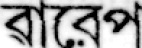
ৱারেপ
